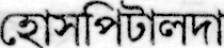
হোসপিটালদা
